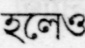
হলেও
